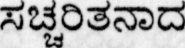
ಸಚ್ಚರಿತನಾದ
